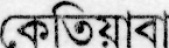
কেতিয়াবা
